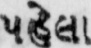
પહેલા
